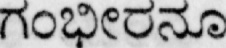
ಗಂಭೀರನೂ
